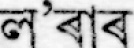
ল'ৰাৰ
